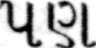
પણ
